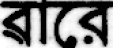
ৱারে
